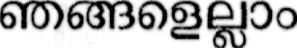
ഞങ്ങളെല്ലാം
